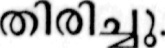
തിരിച്ചു.
